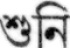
শুনি
